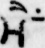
ਮੈਂ
